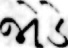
જોડે
